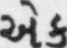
એક
